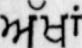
ਅੱਖਾਂ
